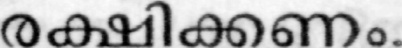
രക്ഷിക്കണം.
